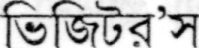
ভিজিটর'স
